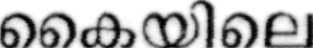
കൈയിലെ
